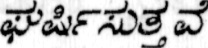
ಘರ್ಷಿಸುತ್ತವೆ
